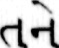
તને
